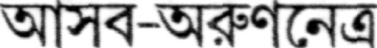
আসব-অরুণনেত্র
